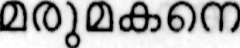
മരുമകനെ
